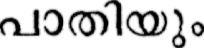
പാതിയും
